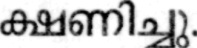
ക്ഷണിച്ചു.
